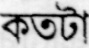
কতটা
